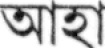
আহা
